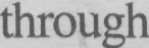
through
